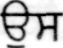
ਉਸ
